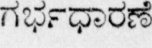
ಗರ್ಭಧಾರಣೆ
